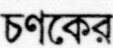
চণকের
